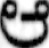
ಆ
